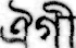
ঐগী
